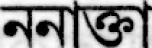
ননাক্তা
